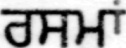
ਰਸਮਾਂ
